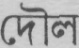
দৌল
